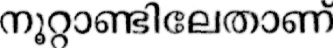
നൂറ്റാണ്ടിലേതാണ്
